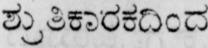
ಶ್ರುತಿಕಾರಕದಿಂದ
